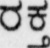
ರಕ್ತ
